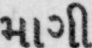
માગી
